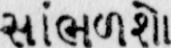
સાંભળશો
